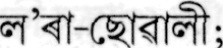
ল'ৰা-ছোৱালী;
